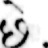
છે.
